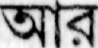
আর
